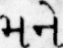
મને
